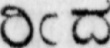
ರಿಂದ
